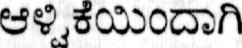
ಆಳ್ವಿಕೆಯಿಂದಾಗಿ
